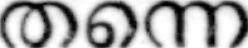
തന്നെ
